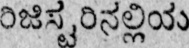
ರಿಜಿಸ್ಟರಿನಲ್ಲಿಯ
